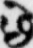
છે
